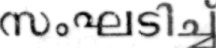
സംഘടിച്ച്
